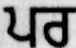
ਪਰ
